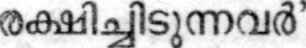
രക്ഷിച്ചിടുന്നവര്‍'
